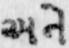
અને
